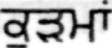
ਕੁੜਮਾਂ
